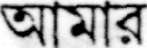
আমার
